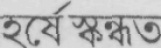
হৰ্ষেস্কন্ধত
